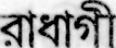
রাধাগী
